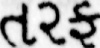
તરફ
